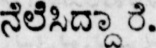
ನೆಲೆಸಿದ್ದಾರೆ.
